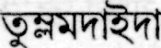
তুম্লমদাইদা
